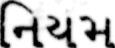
નિયમ
